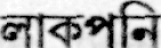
লাকপনি
